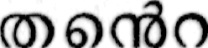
തന്റെ
